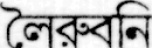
লৈরুবনি
